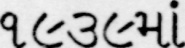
૧૯૩૯માં
